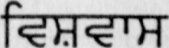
ਵਿਸ਼ਵਾਸ
